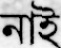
নাই
